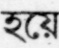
হয়ে
